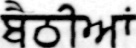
ਬੈਠੀਆਂ
